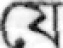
যে
